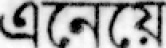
এনেয়ে
